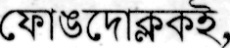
ফোঙদোক্লকই,
